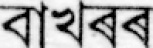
বাখৰৰ
